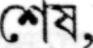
শেষ,
